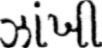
ઝાંખી
